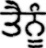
ਤੈਨੂੰ
